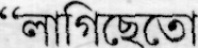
"লাগিছেতো
